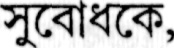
সুবোধকে,
